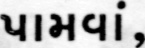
પામવાં,
